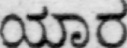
ಯಾರ
